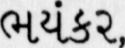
ભયંકર,
